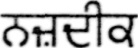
ਨਜ਼ਦੀਕ
